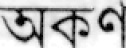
অকণ
